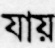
যায়
